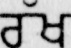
ਰੱਖ
